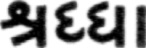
શ્રધ્ધા
